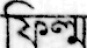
ফিল্ম
